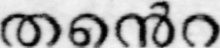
തന്റെ
